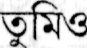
তুমিও
